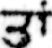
ਤਾਂ
